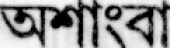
অশাংবা
